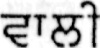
ਵਾਲੀ
